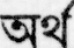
অর্থ
